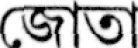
জোতা
